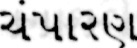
ચંપારણ
